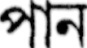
পান
